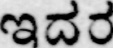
ಇದರ
